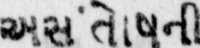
અસંતોષની
